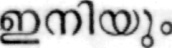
ഇനിയും
